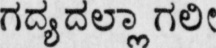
ಗದ್ಯದಲ್ಲಾಗಲೀ
